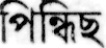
পিন্ধিছ
